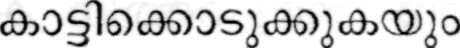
കാട്ടിക്കൊടുക്കുകയും
